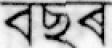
বছৰ
